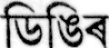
ডিঙিৰ
